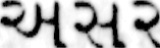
અસર
